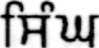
ਸਿੰਘ
